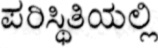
ಪರಿಸ್ಥಿತಿಯಲ್ಲಿ
